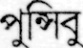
পুন্সিবু
